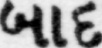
બાદ
